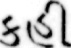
કહી
